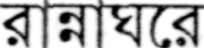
রান্নাঘরে
